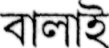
বালাই
